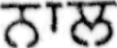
ਨਾਲ
